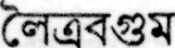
লৈত্রবগুম
